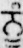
ਨੂੰ
